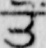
ਤੋਂ
